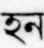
হন
